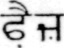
ਫ਼ੈਜ਼
